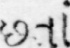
છતાં
